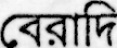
বেরাদি
